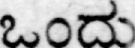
ಒಂದು
